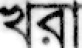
খরা
